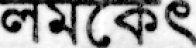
লমকেৎ
